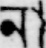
না
